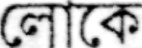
লোকে
